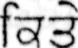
ਕਿਤੇ
